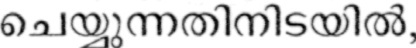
ചെയ്യുന്നതിനിടയില്‍,
